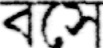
বসে
